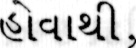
હોવાથી,
